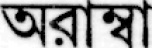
অরাম্বা
